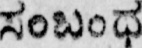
ಸಂಬಂಧ
